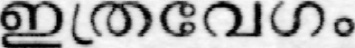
ഇത്രവേഗം
